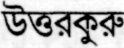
উত্তরকুরু
